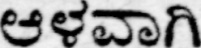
ಆಳವಾಗಿ
